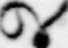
જ
